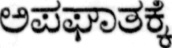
ಅಪಘಾತಕ್ಕೆ
